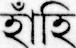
হাঁহি
